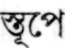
স্তূপে
